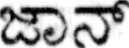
ಜಾನ್
